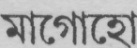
মাগোহো
